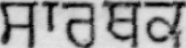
ਸਾਰਥਕ
